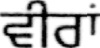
ਵੀਰਾਂ
